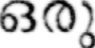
ഒരു
